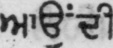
ਆਉਂਦੀ
